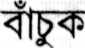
বাঁচুক
